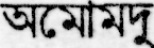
অমোমদু
